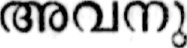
അവനു
